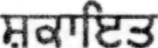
ਸ਼ਕਾਇਤ
